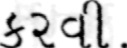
કરવી.
